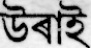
উৰাই
